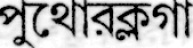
পুথোরক্লগা
